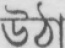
উঠা
